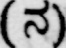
(ನ)
